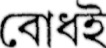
বোধই
